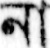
না
